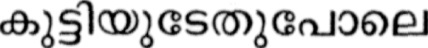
കുട്ടിയുടേതുപോലെ
